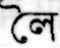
লৈ
